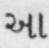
આ
